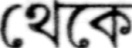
থেকে
